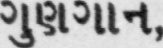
ગુણગાન,
